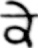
ਕੇ
